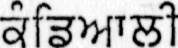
ਕੰਡਿਆਲੀ
